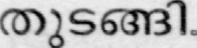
തുടങ്ങി.
